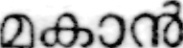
മകാന്‍
